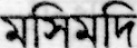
মসিমদি
